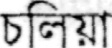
চলিয়া
